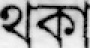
থকা
